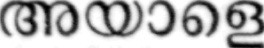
അയാളെ
